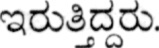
ಇರುತ್ತಿದ್ದರು.
